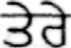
ਤੇਰੇ
